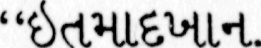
"ઇતમાદખાન.
